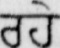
ਰਹੇ
